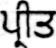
ਪ੍ਰੀਤ
